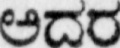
ಅದರ
